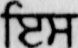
ਇਸ
